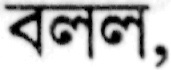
বলল,
